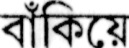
বাঁকিয়ে
